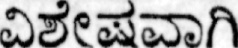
ವಿಶೇಷವಾಗಿ
